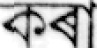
কৰা
